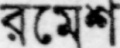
রমেশ
